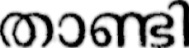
താണ്ടി
